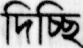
দিচ্ছি
